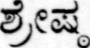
ಶ್ರೇಷ್ಠ
